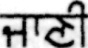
ਜਾਣੀ
